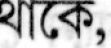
থাকে,
